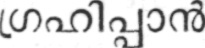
ഗ്രഹിപ്പാന്‍
